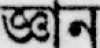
জ্ঞান
